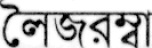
লৈজরম্বা
